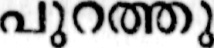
പുറത്തു
